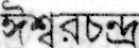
ঈশ্বরচন্দ্র
